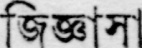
জিজ্ঞাসা
